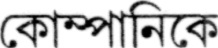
কোম্পানিকে
